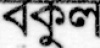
বকুল
